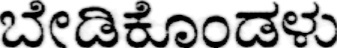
ಬೇಡಿಕೊಂಡಳು
